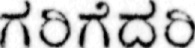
ಗರಿಗೆದರಿ
